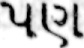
પણ
